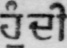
ਹੁੰਦੀ
